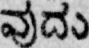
ವುದು
